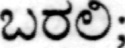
ಬರಲಿ;
